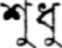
শুধু
